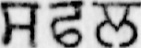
ਸਫਲ
